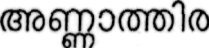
അണ്ണാത്തിര
